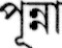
পূন্না
